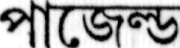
পাজেল্ড
